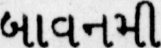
'બાવનમી
